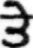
ਤੇ
